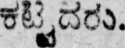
ಕಟ್ಟಿದರು.
